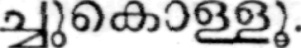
ച്ചുകൊള്ളൂ.
